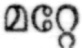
മറ്റേ
